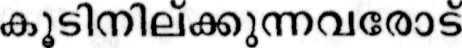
കൂടിനില്ക്കുന്നവരോട്
